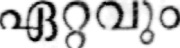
ഏറ്റവും
